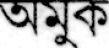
অমুক
